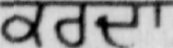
ਕਰਦਾ
